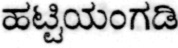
ಹಟ್ಟಿಯಂಗಡಿ
